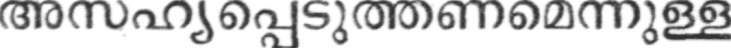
അസഹ്യപ്പെടുത്തണമെന്നുള്ള
